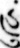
હું
